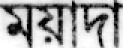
ময়াদা
